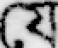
যে
